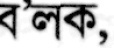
ব'লক,
